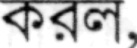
করল,
